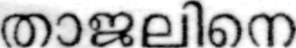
താജലിനെ
